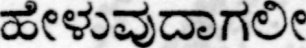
ಹೇಳುವುದಾಗಲೀ
